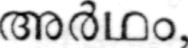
അര്‍ഥം,
